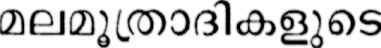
മലമൂത്രാദികളുടെ
